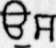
ਉਸ
